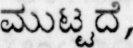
ಮುಟ್ಟದೆ,
